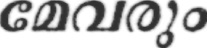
മേവരും
